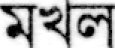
মখল
